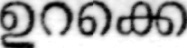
ഉറക്കെ
